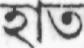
হাত
